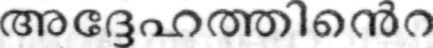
അദ്ദേഹത്തിന്റെ
